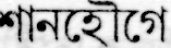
শানহৌগে
